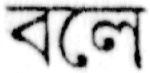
বলে
